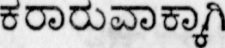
ಕರಾರುವಾಕ್ಕಾಗಿ
